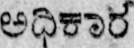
ಅಧಿಕಾರ
